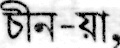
চীন-য়া,
